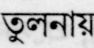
তুলনায়
